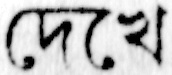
দেখে
